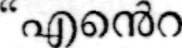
“എന്റെ
